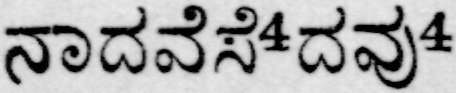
ನಾದವೆಸೆ4ದವು4
